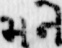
મને
